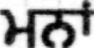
ਮਨਾਂ
